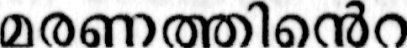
മരണത്തിന്റെ
